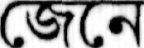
জেনে
